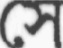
সে
